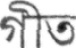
গীত
